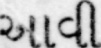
આવી
